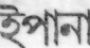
ইপানা
